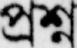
প্রশ্ন
